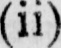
(ii)
